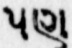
પણ
